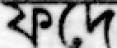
ফদে
